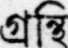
গ্রন্থি
